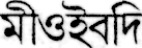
মীওইবদি
